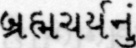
બ્રહ્મચર્યનું
